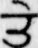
ਤੇ
